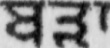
ਬੜਾ
